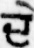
ਦੇ
